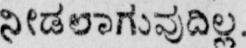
ನೀಡಲಾಗುವುದಿಲ್ಲ.
